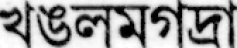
খঙলমগদ্রা
